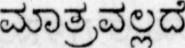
ಮಾತ್ರವಲ್ಲದೆ
